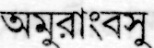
অমুরাংবসু
